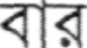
বার
